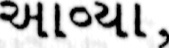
આવ્યા,
